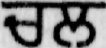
ਚਲ
